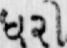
ધરી
